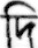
দি
